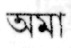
অমা
